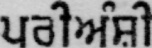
ਪਰੀਅੰਸ਼ੀ
